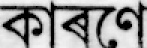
কাৰণে
